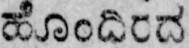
ಹೊಂದಿರದ
